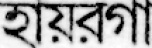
হায়রগা
